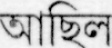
আছিল
